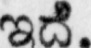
ಇದೆ.
